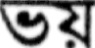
ভয়
